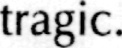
tragic.
